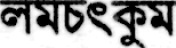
লমচৎকুম
